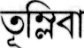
তূম্লিবা
